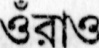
ওঁরাও
